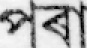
পৰা
